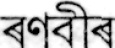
ৰণবীৰ
